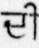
ਦੀ
